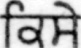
ਕਿਸੇ
